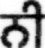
ਨੀ
